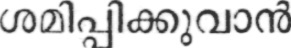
ശമിപ്പിക്കുവാന്‍
